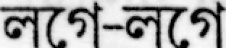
লগে-লগে
